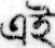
এই
